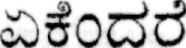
ಏಕೆಂದರೆ
